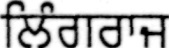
ਲਿੰਗਰਾਜ
